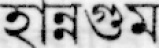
হান্নগুম
